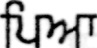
ਪਿਆ
